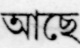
আছে
